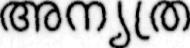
അന്യത്ര
